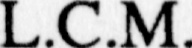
L.C.M.
